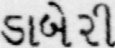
ડાબેરી
